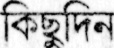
কিছুদিন
